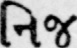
નિજ
